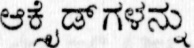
ಆಕ್ಸೈಡ್‌ಗಳನ್ನು
